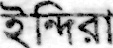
ইন্দিরা
